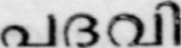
പദവി
